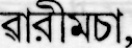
ৱারীমচা,
